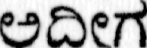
ಅದೀಗ
